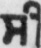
ਸੀ
